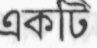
একটি
